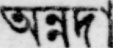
অন্নদা
